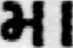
મા
